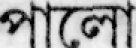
পালো
